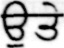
ਉਤੇ
